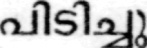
പിടിച്ചു
